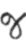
જ
